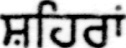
ਸ਼ਹਿਰਾਂ
